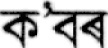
ক'বৰ
